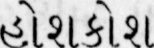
હોશકોશ
